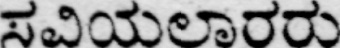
ಸವಿಯಲಾರರು
